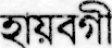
হায়বগী
